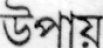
উপায়
